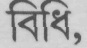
বিধি,
